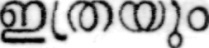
ഇത്രയും
